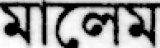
মালেম
